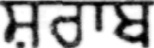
ਸ਼ਰਾਬ
